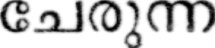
ചേരുന്ന
